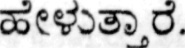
ಹೇಳುತ್ತಾರೆ.
